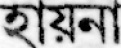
হায়না
